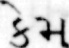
કેમ
